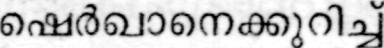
ഷെര്‍ഖാനെക്കുറിച്ച്
